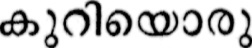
കുറിയൊരു
